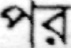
পর
